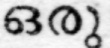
ഒരു
